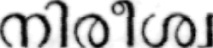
നിരീശ്വ
